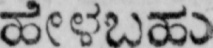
ಹೇಳಬಹು
